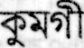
কুমগী
